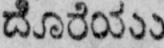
ದೊರೆಯು
